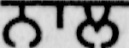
ਨਾਲ
